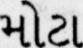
મોટા
